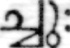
ച്ചു:
